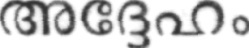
അദ്ദേഹം
